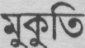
মুকুতি
